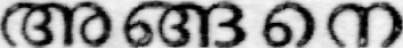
അങ്ങനെ
